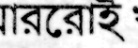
য়াররোই
